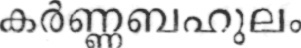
കര്‍ണ്ണബഹുലം
